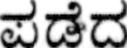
ಪಡೆದ
